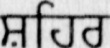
ਸ਼ਹਿਰ
